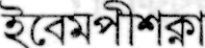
ইবেমপীশক্না
